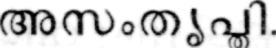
അസംതൃപ്തി.
